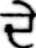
ਦੇ
